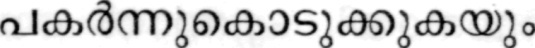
പകര്‍ന്നുകൊടുക്കുകയും
